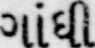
ગાંધી
